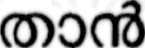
താന്‍
